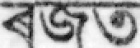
ৰজত
